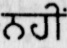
ਨਹੀਂ
